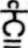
ਨੂੰ
